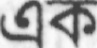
এক
